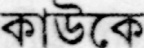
কাউকে
